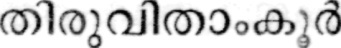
തിരുവിതാംകൂര്‍
